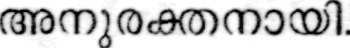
അനുരക്തനായി.
